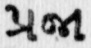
પ્રજા
